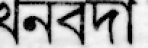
খনবদা
